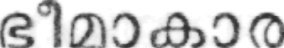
ഭീമാകാര
